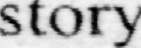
story
